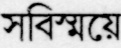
সবিস্ময়ে
